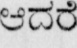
ಆದರೆ
